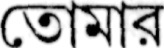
তোমার
